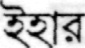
ইহার
